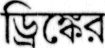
ড্রিঙ্কের
